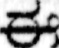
ಈ
